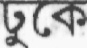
ঢুকে
